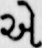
એ
